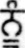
ਨੂੰ
